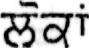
ਲੋਕਾਂ
